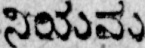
ನಿಯಮ
